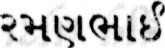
રમણભાઈ
